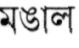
মঙাল
